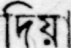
দিয়া
